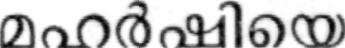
മഹര്‍ഷിയെ
